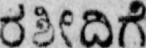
ರಶೀದಿಗೆ
